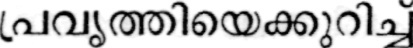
പ്രവൃത്തിയെക്കുറിച്ച്
